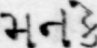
મનકે
